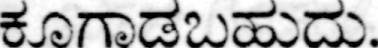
ಕೂಗಾಡಬಹುದು.
